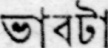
ভাবটা
